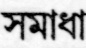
সমাধা
